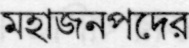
মহাজনপদের
